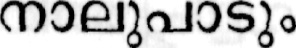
നാലുപാടും
